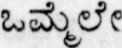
ಒಮ್ಮೆಲೇ
